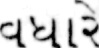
વધારે
